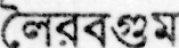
লৈরবগুম
